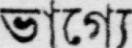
ভাগ্যে
